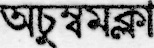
অচুম্বমক্লা
